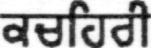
ਕਚਹਿਰੀ
